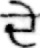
ਦੇ
